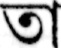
তা
